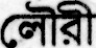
লৌরী
